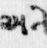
અને
